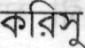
করিসু
